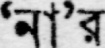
‘না’র
